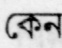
কেন
